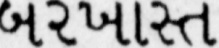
બરખાસ્ત
